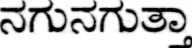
ನಗುನಗುತ್ತಾ
